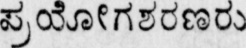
ಪ್ರಯೋಗಶರಣರು
